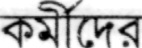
কর্মীদের
